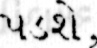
પડશે,
